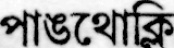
পাঙথোক্লি
